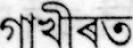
গাখীৰত
